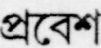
প্রবেশ
